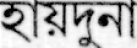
হায়দুনা
